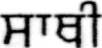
ਸਾਥੀ
